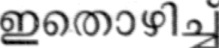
ഇതൊഴിച്ച്
